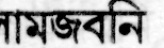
লামজবনি
